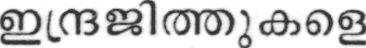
ഇന്ദ്രജിത്തുകളെ
